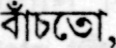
বাঁচতো,
